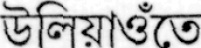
উলিয়াওঁতে
